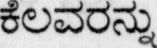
ಕೆಲವರನ್ನು
